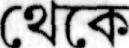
থেকে
